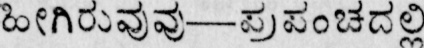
ಹೀಗಿರುವುವು-ಪ್ರಪಂಚದಲ್ಲಿ
